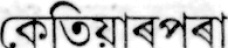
কেতিয়াৰপৰা
